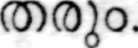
തരും.
